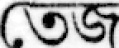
তেজ
